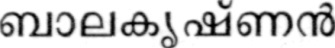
ബാലകൃഷ്ണന്‍
